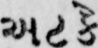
અટકે
